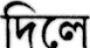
দিলে
